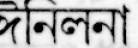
ঈনিলনা
